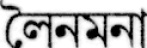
লৈনমনা
